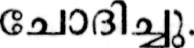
ചോദിച്ചു.
